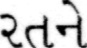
રતને
